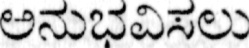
ಅನುಭವಿಸಲು
